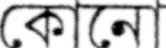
কোনো
